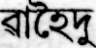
ৱাহৈদু
